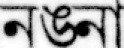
নঙনা
